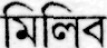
মিলিব
